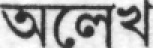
অলেখ
